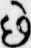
છે
